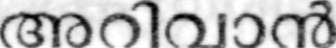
അറിവാന്‍
